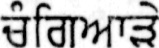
ਚੰਗਿਆੜੇ
